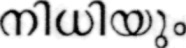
നിധിയും
